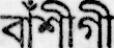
বাশীগী
